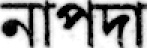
নাপদা
